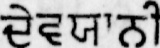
ਦੇਵਯਾਨੀ
